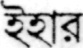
ইহার
